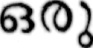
ഒരു
